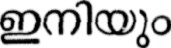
ഇനിയും
